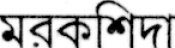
মরকশিদা
